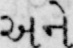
અને
